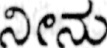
ನೀನು
